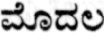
ಮೊದಲ
